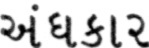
અંધકા
